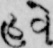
હવે
